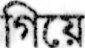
গিয়ে
